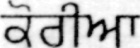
ਕੋਰੀਆ
